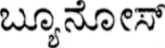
ಬ್ಯೂನೋಸ್
